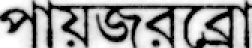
পায়জরব্রো
